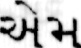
એમ
